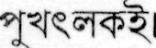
পুখৎলকই।
